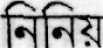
নিনিয়
